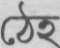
ঠেহ
